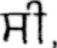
ਸੀ,
